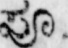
ಪೂ.
